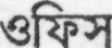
ওফিস
